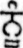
ਨੂੰ
